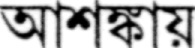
আশঙ্কায়
